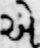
એ
